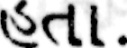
હતા.
